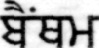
ਬੈਂਥਮ
